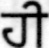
ਹੀ
